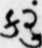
કરું
